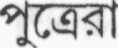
পুত্রেরা
